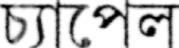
চ্যাপেল
